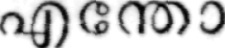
എന്തോ
